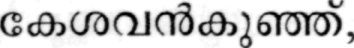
കേശവന്‍കുഞ്ഞ്,
